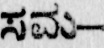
ಸಮ-
